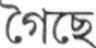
গৈছে
